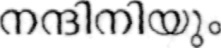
നന്ദിനിയും
